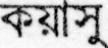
কয়াসু
